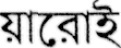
য়ারোই
